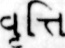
વૃત્તિ
